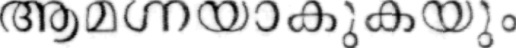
ആമഗ്നയാകുകയും
